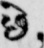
છે,
